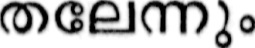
തലേന്നും
